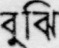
বুঝি
